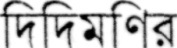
দিদিমণির
